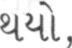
થયો,
